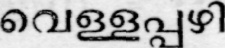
വെള്ളപ്പഴി
